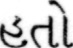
હતો
